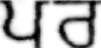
ਪਰ
